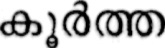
കൂര്‍ത്ത
